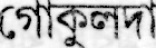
গোকুলদা
